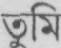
তুমি
